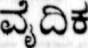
ವೈದಿಕ
